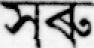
সৰু
